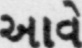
આવે
